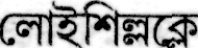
লোইশিল্লক্লে
